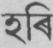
হৰি
